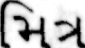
મિત્ર
